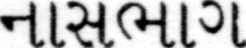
નાસભાગ
